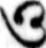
ও
